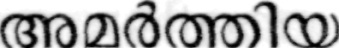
അമര്‍ത്തിയ
